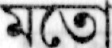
মতো
